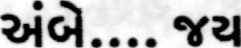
અંબે.....જય
